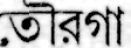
তৌরগা
